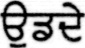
ਉਡਦੇ
